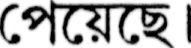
পেয়েছে।
